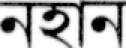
নহান
